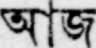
আজ
